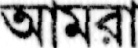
আমরা
